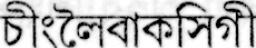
চীংলৈবাকসিগী
